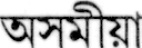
অসমীয়া
